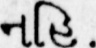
નહિ.
